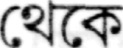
থেকে
